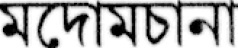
মদোমচানা
